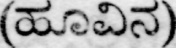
(ಹೂವಿನ)
